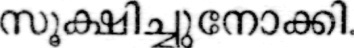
സൂക്ഷിച്ചുനോക്കി.
